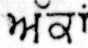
ਅੱਕਾਂ
